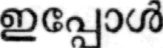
ഇപ്പോള്‍
